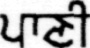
ਪਾਣੀ
